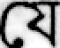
যে
